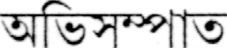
অভিসম্পাত
